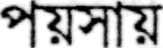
পয়সায়
